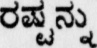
ರಷ್ಟನ್ನು
